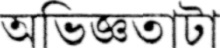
অভিজ্ঞতাটা
